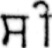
ਸੀ
